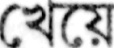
খেয়ে
